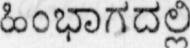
ಹಿಂಭಾಗದಲ್ಲಿ
